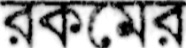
রকমের
